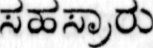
ಸಹಸ್ರಾರು
